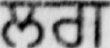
ਲਗ
